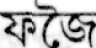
ফজৈ
